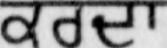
ਕਰਦਾ
